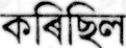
কৰিছিল
